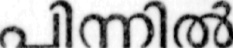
പിന്നില്‍
